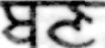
ਬਣ
